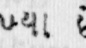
રાખ્યા
